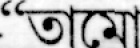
“তামো
